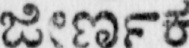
ಜೀರ್ಣಕ
